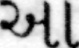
આ
